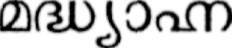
മദ്ധ്യാഹ്ന
